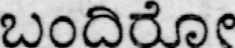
ಬಂದಿರೋ
